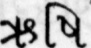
ઋષિ
